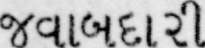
જવાબદારી
